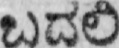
ಬದಲಿ
